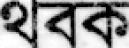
থবক
